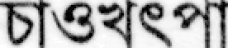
চাওখৎপা
